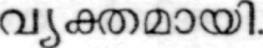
വ്യക്തമായി.
